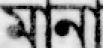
মানা
